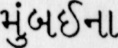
મુંબઈના
